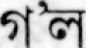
গ'ল
